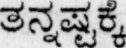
ತನ್ನಷ್ಟಕ್ಕೆ
